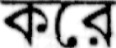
করে
